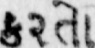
કરતો
